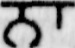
ਨਾ
